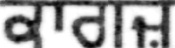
ਕਾਗਜ਼
